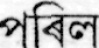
পৰিল
